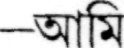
-আমি
